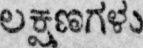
ಲಕ್ಷಣಗಳು
